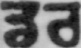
ਡਰ
